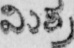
ಮಿಶ್ರ
